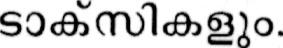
ടാക്സികളും.
